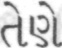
તેણે
